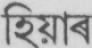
হিয়াৰ
